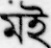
মই
